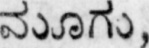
ಮೂಗು,
